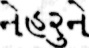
નેહરુને
